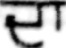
ਦਾ
